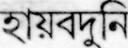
হায়বদুনি
